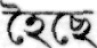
হৈছে
